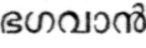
ഭഗവാന്‍
